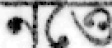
নত্তে
